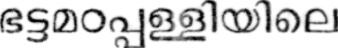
ഭട്ടമഠപ്പള്ളിയിലെ
